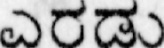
ಎರಡು
